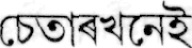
চেতাৰখনেই
